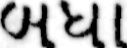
બધા
